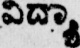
ವಿದ್ಯಾ
